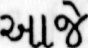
આજે
